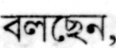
বলছেন,
